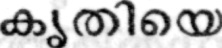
കൃതിയെ
